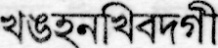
খঙহনখিবদগী
